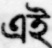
এই
